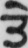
ਤੇ
